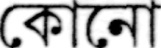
কোনো
